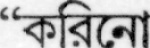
“করিনো
